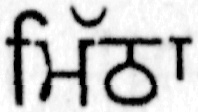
ਮਿੱਠਾ
